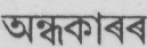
অন্ধকাৰৰ
